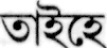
তাইহে
